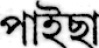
পাইছা
